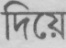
দিয়ে
